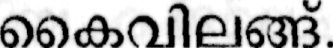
കൈവിലങ്ങ്.
